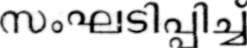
സംഘടിപ്പിച്ച്
